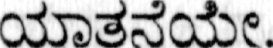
ಯಾತನೆಯೇ.
